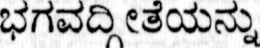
ಭಗವದ್ಗೀತೆಯನ್ನು
